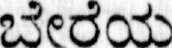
ಬೇರೆಯ
